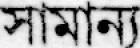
সামান্য
